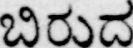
ಬಿರುದ
